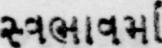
સ્વભાવમાં
